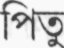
পিতু
